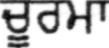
ਚੂਰਮਾ
